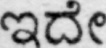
ಇದೇ
